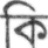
কি
